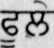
ਫੂਲੇ
